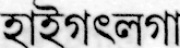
হাইগৎলগা
